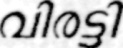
വിരട്ടി
